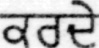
ਕਰਦੇ
